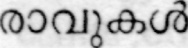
രാവുകള്‍
